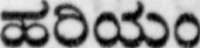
ಹರಿಯಂ
